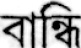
বান্ধি
